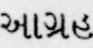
આગ્રહ
